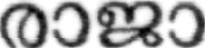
രാജാ
